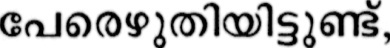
പേരെഴുതിയിട്ടുണ്ട്,
